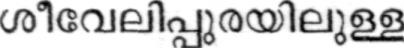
ശീവേലിപ്പുരയിലുള്ള
